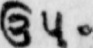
ઉપ-
